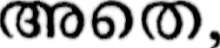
അതെ,
